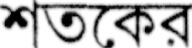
শতকের
